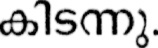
കിടന്നു.
